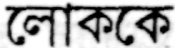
লোককে
